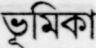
ভূমিকা
